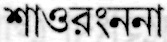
শাওরংননা
